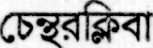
চেন্থরক্লিবা
